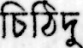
চিঠিদু
